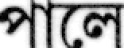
পালে
